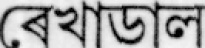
ৰেখাডাল
